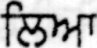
ਲਿਆ
